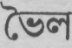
ভৈল
